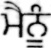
ਮੈਨੂੰ
